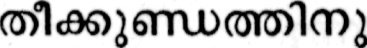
തീക്കുണ്ഡത്തിനു
